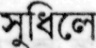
সুধিলে
